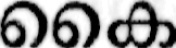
കൈ
